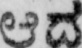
ಆದ
